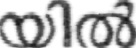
യില്‍
